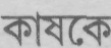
কাষকে
